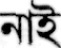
নাই
